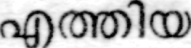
എത്തിയ
